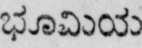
ಭೂಮಿಯ
